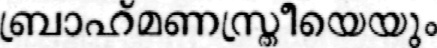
ബ്രാഹ്മണസ്ത്രീയെയും
